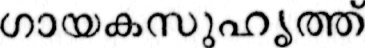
ഗായകസുഹൃത്ത്
